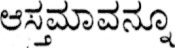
ಆಸ್ತಮಾವನ್ನೂ
